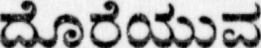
ದೊರೆಯುವ
